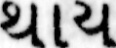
થાય
